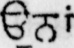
ਉਨ੍ਹਾਂ
